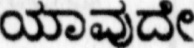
ಯಾವುದೇ
